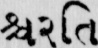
શ્વરતિ
